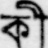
কী
